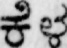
ಕೆಳ
